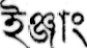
ইঞ্জাং
